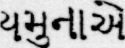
યમુનાએ
